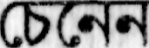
চেনেন
